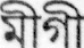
মীগী
